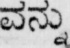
ವನ್ನು
